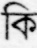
কি
